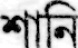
শানি
